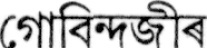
গোবিন্দজীৰ
